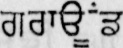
ਗਰਾਉਂਡ
